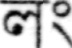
লং
